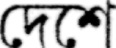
দেশে
